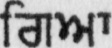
ਗਿਆ
